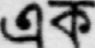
এক
